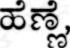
ಹೆಣ್ಣೆ,
